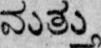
ಮತ್ತು
